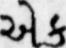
એક
